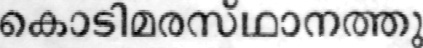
കൊടിമരസ്ഥാനത്തു
